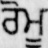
ਰੋਮੂ
